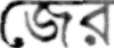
জের
